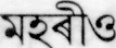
মহৰীও
